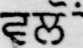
ਵਲੋਂ
